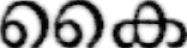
കൈ
